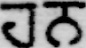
ਹਨ
